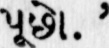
પૂછો.'
